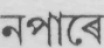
নপাৰে
